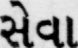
સેવા
